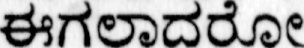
ಈಗಲಾದರೋ
